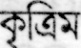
কৃত্রিম
